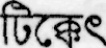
টিক্কেৎ
